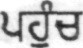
ਪਹੁੰਚ
